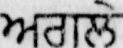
ਅਗਲੇ
